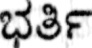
ಭರ್ತಿ
